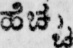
ಹೆಚ್ಚು
